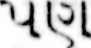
પણ
